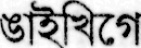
ঙাইখিগে
